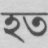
হত
